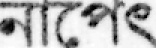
নাপেৎ
